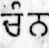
ਚੰਨ
